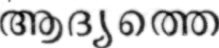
ആദ്യത്തെ
